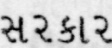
સરકાર
